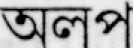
অলপ
